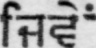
ਜਿਵੇਂ
